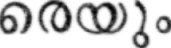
രെയും
